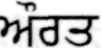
ਔਰਤ
